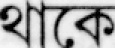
থাকে
